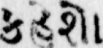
કહેશો
